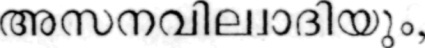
അസനവില്വാദിയും,
